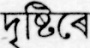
দৃষ্টিৰে
